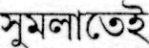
সুমলাতেই
